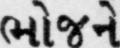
ભોજને
